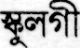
স্কুলগী
